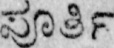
ಪೂರ್ತಿ
